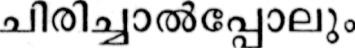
ചിരിച്ചാല്‍പ്പോലും
